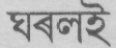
ঘৰলই
